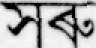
সৰু
